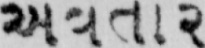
અવતાર
